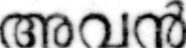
അവന്‍
